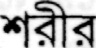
শরীর
